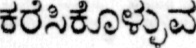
ಕರೆಸಿಕೊಳ್ಳುವ
